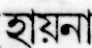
হায়না
